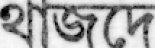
থাজদে
